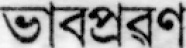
ভাবপ্রৱণ
